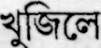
খুজিলে
